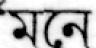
'মনে
